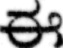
ಈ
